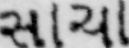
સાચા
